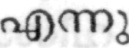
എന്നു
